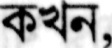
কখন,
